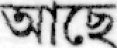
আছে
